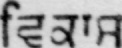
ਵਿਕਾਸ
